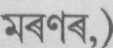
মৰণৰ,)
